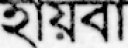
হায়বা
